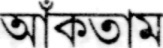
আঁকতাম
